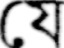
যে
